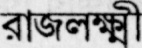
রাজলক্ষ্মী
